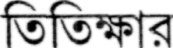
তিতিক্ষার
